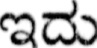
ಇದು
